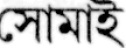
সোমাই
